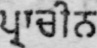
ਪ੍ਰਾਚੀਨ
